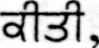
ਕੀਤੀ,
